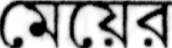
মেয়ের
